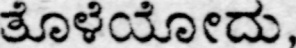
ತೊಳೆಯೋದು,
